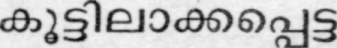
കൂട്ടിലാക്കപ്പെട്ട
